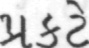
પ્રકટે
